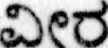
ವೀರ
